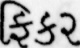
ફિકર
